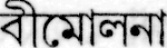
বীমোলনা
